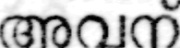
അവന്
